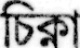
চিক্না
